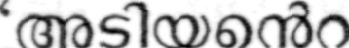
‘അടിയന്റെ
